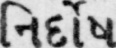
નિર્દોષ
